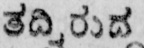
ತದ್ವಿರುದ್ಧ
